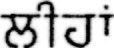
ਲੀਹਾਂ
